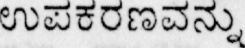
ಉಪಕರಣವನ್ನು
